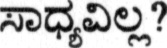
ಸಾಧ್ಯವಿಲ್ಲ?
